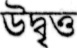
উদ্বৃত্ত
